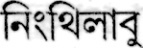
নিংথিলাবু
